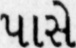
પાસે
